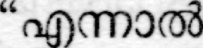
“എന്നാല്‍
